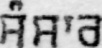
ਸੰਸਾਰ
